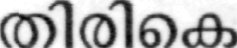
തിരികെ
